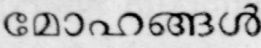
മോഹങ്ങള്‍
